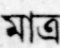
মাত্র
